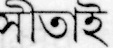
সীতাই
